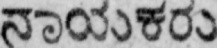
ನಾಯಕರು
